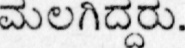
ಮಲಗಿದ್ದರು.
